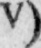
v)
